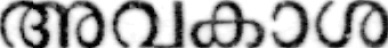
അവകാശ
